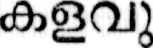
കളവു
